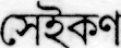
সেইকণ
